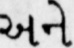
અને
